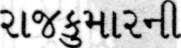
રાજકુમારની
